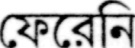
ফেরেনি
